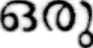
ഒരു
